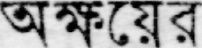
অক্ষয়ের
